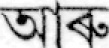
আৰু
